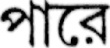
পারে
